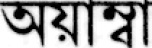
অয়াম্বা
